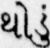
થોડું
